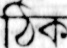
ঠিক
